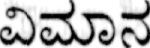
ವಿಮಾನ
